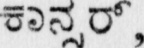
ಕಾನ್ಸರ್,
